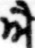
ਐ
